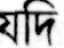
যদি
